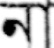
না
